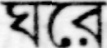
ঘরে
